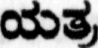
ಯತ್ರ
